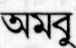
অমবু
